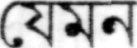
যেমন
